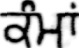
ਕੰਮਾਂ
